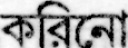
করিনো
